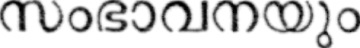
സംഭാവനയും
